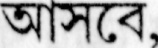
আসবে,
